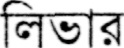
লিভার
